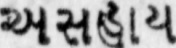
અસહાય
